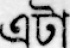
এটা
